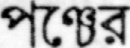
পঞ্চের
